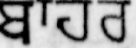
ਬਾਹਰ
